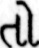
તો
